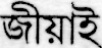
জীয়াই
